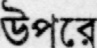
উপরে
